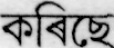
কৰিছে
